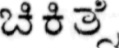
ಚಿಕಿತ್ಸೆ
